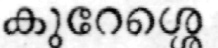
കുറേശ്ശെ
